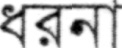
ধরনা
